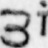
ਤਾਂ
